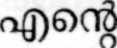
എന്റെ
